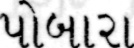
પોબારા
